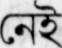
নেই
